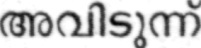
അവിടുന്ന്
